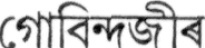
গোবিন্দজীৰ
